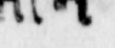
ભાન
